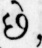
છે,
